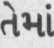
તેમાં
